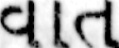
વાત
